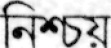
নিশ্চয়
